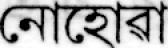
নোহোৱা
